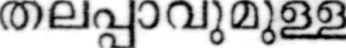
തലപ്പാവുമുള്ള
